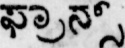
ಫ್ರಾನ್ಸ್
